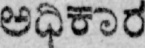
ಅಧಿಕಾರ
